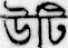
উটি
